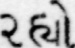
રહ્યો
